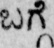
ಬಗ್ಗೆ
